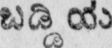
ಬಡ್ಡಿಯ
